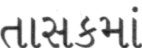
તાસકમાં
